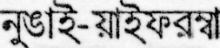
নুঙাই-য়াইফরম্বা
